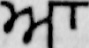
ਆ
